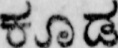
ಕೂಡ
